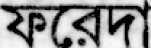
ফরেদা
